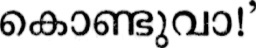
കൊണ്ടുവാ!’
